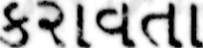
કરાવતા
